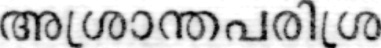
അശ്രാന്തപരിശ്ര
